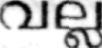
വല്ല
